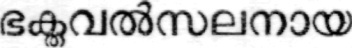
ഭക്തവല്‍സലനായ
